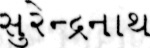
સુરેન્દ્રનાથ
